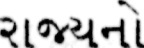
રાજ્યનો
